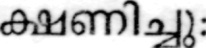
ക്ഷണിച്ചു:
